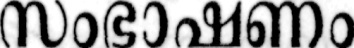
സംഭാഷണം
